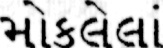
મોકલેલાં
